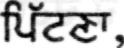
ਪਿੱਟਣਾ,
